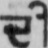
ਦੀ
